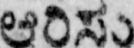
ಆರಿಸು
